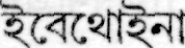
ইবেথোইনা
